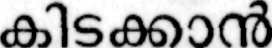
കിടക്കാന്‍
